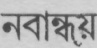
নবান্ধয়
